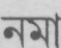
নমা
